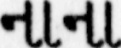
નાના
